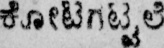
ಕೋಟಿಗಟ್ಟಲೆ
